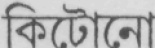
কিটোনো
